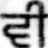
ਵੀ
